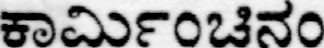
ಕಾರ್ಮಿಂಚಿನಂ
